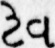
ટેવ
